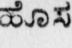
ಹೊಸ
